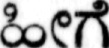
ಹೀಗೆ
